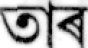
তাৰ
